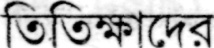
তিতিক্ষাদের
